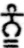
ਨੂੰ
